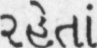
રહેતાં
